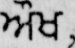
ਔਖ,
